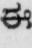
ಈ
